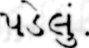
પડેલું.
